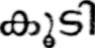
കൂടി
